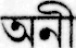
অনী
